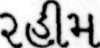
રહીમ
